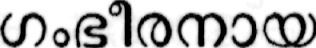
ഗംഭീരനായ
